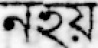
নহয়
